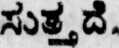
ಸುತ್ತದೆ.
